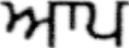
ਆਪ
